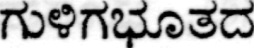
ಗುಳಿಗಭೂತದ
